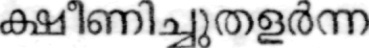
ക്ഷീണിച്ചുതളര്‍ന്ന
